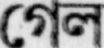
গেল
